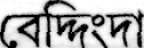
বেদ্দিংদা
